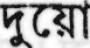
দুয়ো
